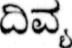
ದಿವ್ಯ
